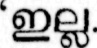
'ഇല്ല.
